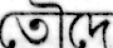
তৌদে
